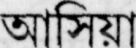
আসিয়া
